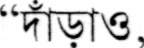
“দাঁড়াও,
